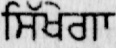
ਸਿੱਖੇਗਾ
